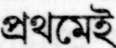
প্রথমেই
